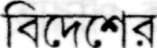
বিদেশের
